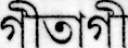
গীতাগী
